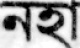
নহা
